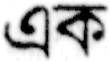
এক
